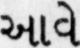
આવે
